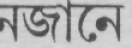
নজানে
